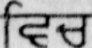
ਵਿਚ
